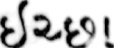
ઇચ્છા
